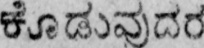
ಕೊಡುವುದರ
